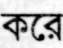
করে
